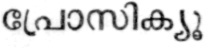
പ്രോസിക്യൂ
